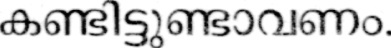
കണ്ടിട്ടുണ്ടാവണം.
